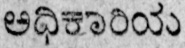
ಅಧಿಕಾರಿಯ
